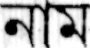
নাম
